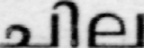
ചില
